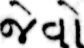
જેવો
